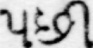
પછી
